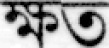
ক্ষত
